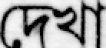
দেখা
